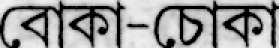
বোকা-চোকা
